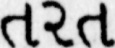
તરત
